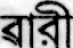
ৱারী
